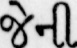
જેની
